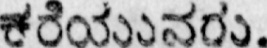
ಕರೆಯುವರು.
